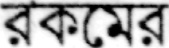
রকমের
